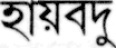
হায়বদু
